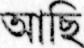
আছি
